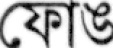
ফোঙ
